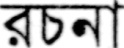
রচনা
